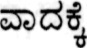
ವಾದಕ್ಕೆ
